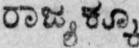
ರಾಜ್ಯಕ್ಕೂ
